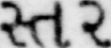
સ્તર
